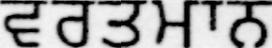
ਵਰਤਮਾਨ
